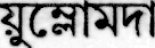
য়ুম্লোমদা
